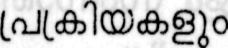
പ്രക്രിയകളും
